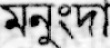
মনুংদা
